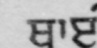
ਥਾੲ
